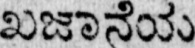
ಖಜಾನೆಯ
